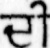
ਦੀ
